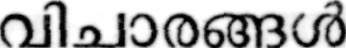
വിചാരങ്ങള്‍
